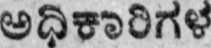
ಅಧಿಕಾರಿಗಳ
